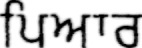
ਪਿਆਰ
